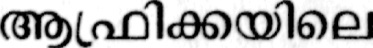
ആഫ്രിക്കയിലെ
